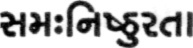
સમઃનિષ્ઠુરતા
